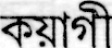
কয়াগী
